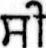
ਸੀ
